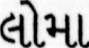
લોમા
